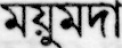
ময়ুমদা
